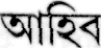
আহিব
